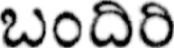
ಬಂದಿರಿ
